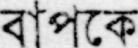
বাপকে
